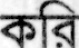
করি
